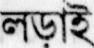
লড়াই
